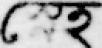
স্নেহ
